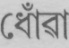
ধোঁৱা
